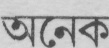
অনেক
